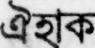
ঐহাক
